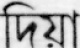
দিয়া
